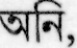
অনি,
